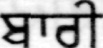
ਬਾਰੀ
